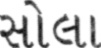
સોલા
